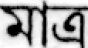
মাত্র
